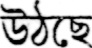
উঠছে
